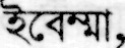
ইবেম্মা,
